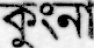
কুংনা
